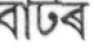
বাটৰ
